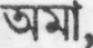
অমা,
